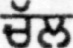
ਚੱਲ
